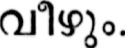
വീഴും.
